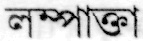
লম্পাক্তা
